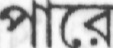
পারে
